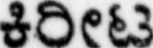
ಕಿರೀಟ
